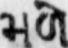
મળે
